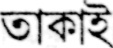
তাকাই
